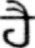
ਹੈ
